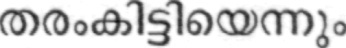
തരംകിട്ടിയെന്നും
